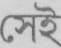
সেই
